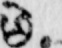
છે.
